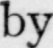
by
